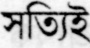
সত্যিই
